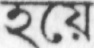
হয়ে
